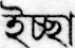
ইচ্ছা
